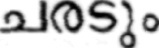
ചരടും
